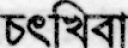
চৎখিবা
